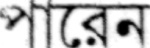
পারেন
